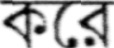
করে
